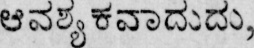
ಆವಶ್ಯಕವಾದುದು,
